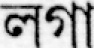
লগা
